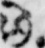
છે.
